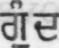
ਗੁੰਦ
